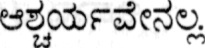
ಆಶ್ಚರ್ಯವೇನಲ್ಲ.
